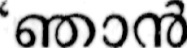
‘ഞാന്‍
